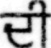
ਦੀ
